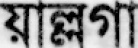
য়াল্লগা
